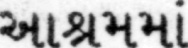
આશ્રમમાં
